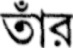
তাঁর
